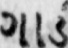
ગાડી
